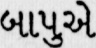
બાપુએ
